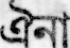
ঐনা
